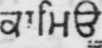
ਕਾਮਿਊ
